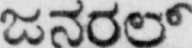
ಜನರಲ್
